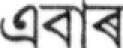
এবাৰ
